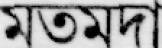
মতমদা
